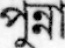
পুন্না
